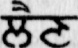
ਲੈਣ
